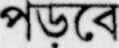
পড়বে
